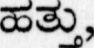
ಹತ್ತು,
